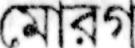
মোরগ
